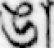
ঙা
